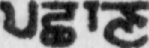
ਪਛਾਣ
